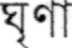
ঘৃণা
